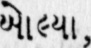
બોલ્યા,
